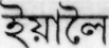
ইয়ালৈ
